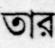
তার
